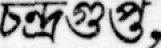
চন্দ্রগুপ্ত,
